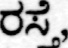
ರಸ್ತೆ,
